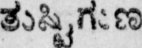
ತುಷ್ಟಿಗುಣ
